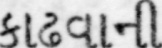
કાઢવાની
